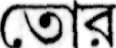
তোর
